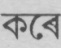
কৰে
